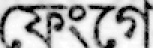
ফেংগে
